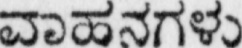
ವಾಹನಗಳು
